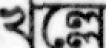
খল্লে
